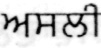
ਅਸਲੀ
